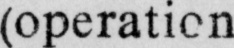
(operation
